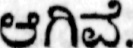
ಆಗಿವೆ.
